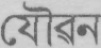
যৌৱন
